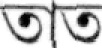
তাত
